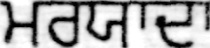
ਮਰਯਾਦਾ
